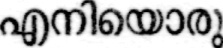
എനിയൊരു
